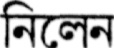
নিলেন
